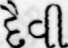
દૈવી
